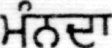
ਮੰਨਦਾ
